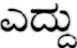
ಎದ್ದು
